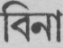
বিনা
